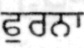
ਫੁਰਨਾ
